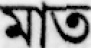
মাত
